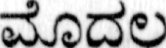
ಮೊದಲ
